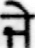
ਜੇ
